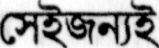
সেইজন্যই
